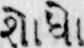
શોધો
